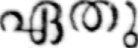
ഏതു
